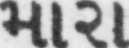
મારા
